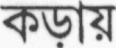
কড়ায়
